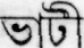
ভাটী
